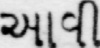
આવી
